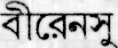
বীরেনসু
